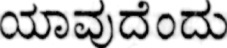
ಯಾವುದೆಂದು
